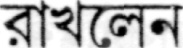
রাখলেন
